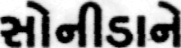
સોનીડાને
